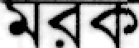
মরক
